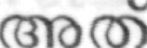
അത്
